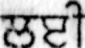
ਲਈ
